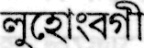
লুহোংবগী
